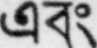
এবং
